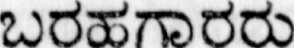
ಬರಹಗಾರರು
